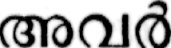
അവര്‍
